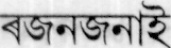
ৰজনজনাই
